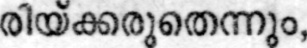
രിയ്ക്കരുതെന്നും,
